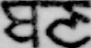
ਬਣ
